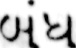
બંધ
